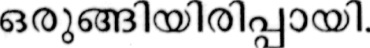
ഒരുങ്ങിയിരിപ്പായി.
